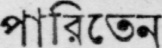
পারিতেন
